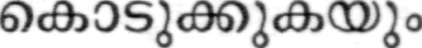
കൊടുക്കുകയും
